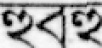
হুবহু
